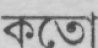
কতো
